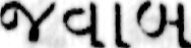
જવાબ
